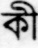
কী
